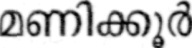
മണിക്കൂര്‍
